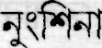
নুংশিনা
